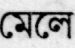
মেলে
